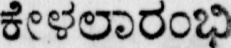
ಕೇಳಲಾರಂಭಿ
